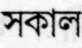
সকাল
